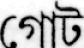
গোট
